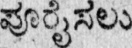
ಪೂರೈಸಲು
